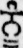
ਨੂੰ
